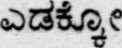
ಎಡಕ್ಕೋ
